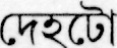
দেহটো
